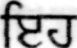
ਇਹ
